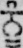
ਨੂੰ
